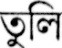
তুলি
